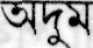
অদুম
